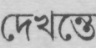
দেখন্তে
